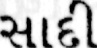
સાદી
